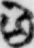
છે
